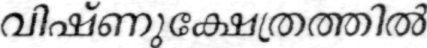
വിഷ്ണുക്ഷേത്രത്തില്‍
